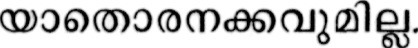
യാതൊരനക്കവുമില്ല.
